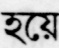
হয়ে
